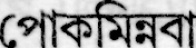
পোকমিন্নবা
